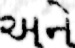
અને
